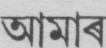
আমাৰ
